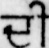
ਦੀ
